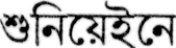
শুনিয়েইনে
